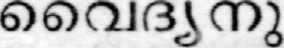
വൈദ്യനു
